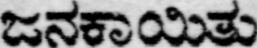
ಜನಕಾಯಿತು
